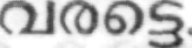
വരട്ടെ.
